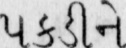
પકડીને
